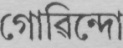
গোৱিন্দো
